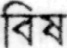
বিষ
